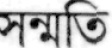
সন্মতি
